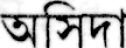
অসিদা
